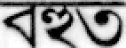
বহুত
